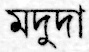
মদুদা
